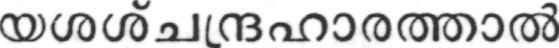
യശശ്ചന്ദ്രഹാരത്താല്‍
